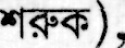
শরুক)
